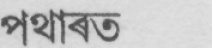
পথাৰত
